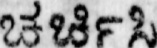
ಚರ್ಚಿಸಿ
